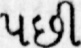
પછી
